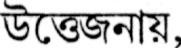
উত্তেজনায়,
